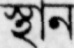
স্থান
